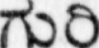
ಗುರಿ
